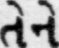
તેને
